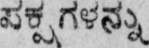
ಪಕ್ಷಗಳನ್ನು
